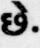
છે.
